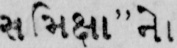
સમિક્ષા”નો
